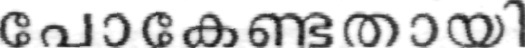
പോകേണ്ടതായി
